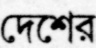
দেশের
